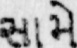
સામે
